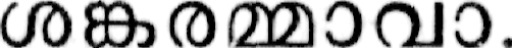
ശങ്കരമ്മാവാ.
